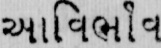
આવિર્ભાવ
